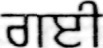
ਗਈ
